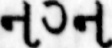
નગ્ન
